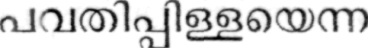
പവതിപ്പിള്ളയെന്ന
